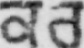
ਕਰ
